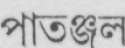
পাতঞ্জল
